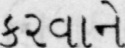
કરવાને
